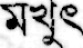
মখুৎ
